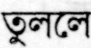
তুললে
